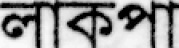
লাকপা
